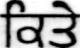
ਕਿਤੇ
